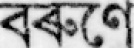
বৰুণে
